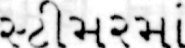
સ્ટીમરમાં
